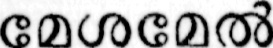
മേശമേല്‍
